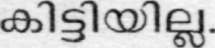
കിട്ടിയില്ല.
